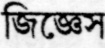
জিজ্ঞেস
